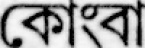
কোংবা
